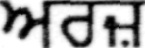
ਅਰਜ਼
